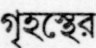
গৃহস্থের
